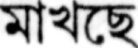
মাখছে
